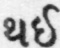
થઈ
